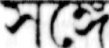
সঙ্গে
